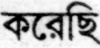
করেছি
